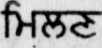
ਮਿਲਣ
